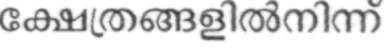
ക്ഷേത്രങ്ങളില്‍നിന്ന്
